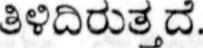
ತಿಳಿದಿರುತ್ತದೆ.
